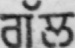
ਗੱਲ
